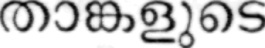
താങ്കളുടെ
